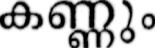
കണ്ണും
